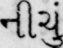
નીચું
